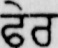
ਫੇਰ
